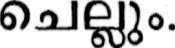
ചെല്ലും.
